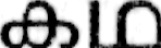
കഥ
